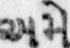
અમે
